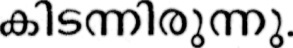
കിടന്നിരുന്നു.
